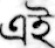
এই
